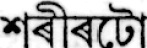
শৰীৰটো
